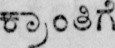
ಕ್ರಾಂತಿಗೆ
